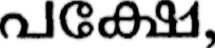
പക്ഷേ,
